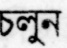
চলুন
